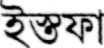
ইস্তফা
